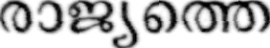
രാജ്യത്തെ
